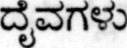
ದೈವಗಳು
